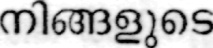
നിങ്ങളുടെ
